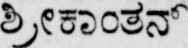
ಶ್ರೀಕಾಂತನ್
